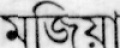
মজিয়া
